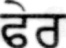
ਫੇਰ
